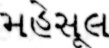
મહેસૂલ
